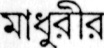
মাধুরীর
